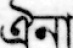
ঐনা
